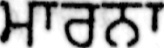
ਮਾਰਨਾ
